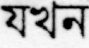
যখন
